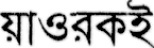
য়াওরকই
